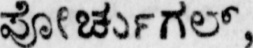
ಪೋರ್ಚುಗಲ್,
